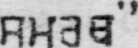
ਸਮਰਥ''
